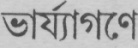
ভাৰ্য্যাগণে
